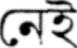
নেই
